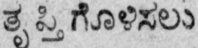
ತೃಪ್ತಿಗೊಳಿಸಲು
